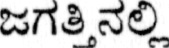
ಜಗತ್ತಿನಲ್ಲಿ
